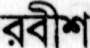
রবীশ
